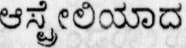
ಆಸ್ಟ್ರೇಲಿಯಾದ
